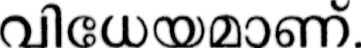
വിധേയമാണ്.
